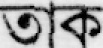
তাক
